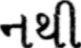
નથી
